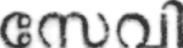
സേവി
